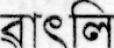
ৱাৎলি
